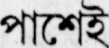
পাশেই
